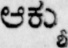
ಆಕ್ಯು
